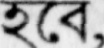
হবে,
